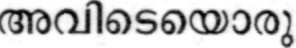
അവിടെയൊരു
